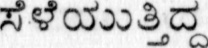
ಸೆಳೆಯುತ್ತಿದ್ದ
